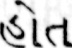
હોત
